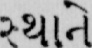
સ્થાને
